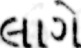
લાગે
